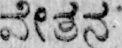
ವೇತನ
